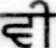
ਵੀ
